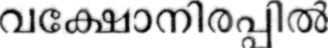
വക്ഷോനിരപ്പില്‍
